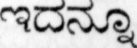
ಇದನ್ನೂ
